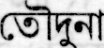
তৌদুনা
